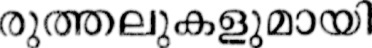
രുത്തലുകളുമായി
